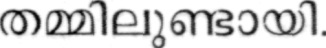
തമ്മിലുണ്ടായി.
